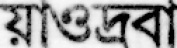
য়াওদ্রবা
